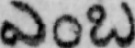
ಎಂಬ
